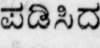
ಪಡಿಸಿದ
